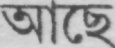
আছে
